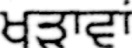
ਖੜਾਵਾਂ
